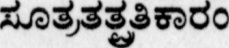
ಸೂತ್ರತತ್ಪ್ರತಿಕಾರಂ
